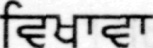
ਵਿਖਾਵਾ
